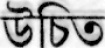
উচিত
